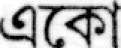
একো
